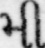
મી
